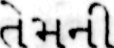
તેમની
